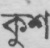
কুশ
